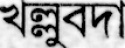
খল্লুবাদ
